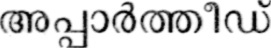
അപ്പാര്‍ത്തീഡ്
